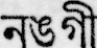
নঙগী
